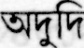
অদুদি
